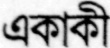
একাকী
